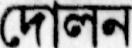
দোলন
